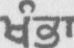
ਖੰਭਾ
